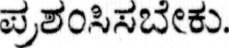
ಪ್ರಶಂಸಿಸಬೇಕು.
